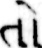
તો
